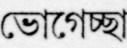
ভোগেচ্ছা
